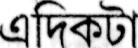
এদিকটা
